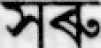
সৰু
